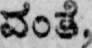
ವಂತೆ,
